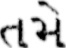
તમે
